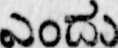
ಎಂದು
